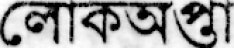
লোকঅপ্তা
